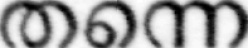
തന്നെ
